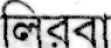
লিরবা
